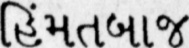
હિંમતબાજ
